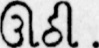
ઊઠી.
